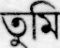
তুমি
